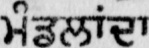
ਮੰਡਲਾਂਦਾ
